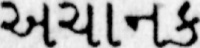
અચાનક
